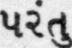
પરંતુ
